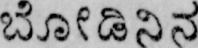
ಬೋಡಿನಿನ
